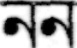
নন
